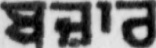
ਬਜ਼ਾਰ
